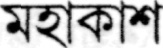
মহাকাশ
